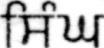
ਸਿੰਘ
